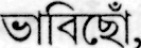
ভাবিছোঁ,
